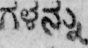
ಗಳನ್ನು
